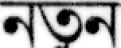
নতুন
